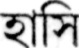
হাসি
